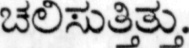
ಚಲಿಸುತ್ತಿತ್ತು.
